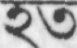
হত
